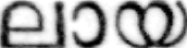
ലായ
